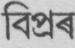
বিপ্ৰৰ
